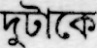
দুটাকে
